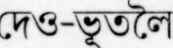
দেও-ভূতলৈ
